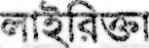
লাইরিক্তা
